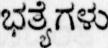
ಭತ್ಯೆಗಳು
